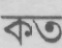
কত
